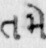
તમે
